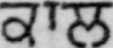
ਕਾਲ
